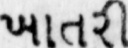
ખાતરી
